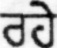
ਰਹੇ
